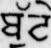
ਬੁੱਟੇ
